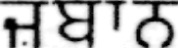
ਜ਼ਬਾਨ
